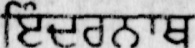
ਇੰਦਰਨਾਥ
